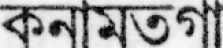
কনামতগা
